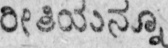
ರೀತಿಯನ್ನೂ
